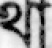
থা
